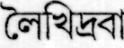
লৈখিদ্রবা
